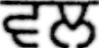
ਵਲ
